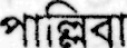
পাল্লিবা
